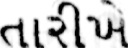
તારીખે
